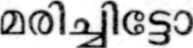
മരിച്ചിട്ടോ
